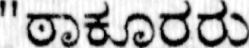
“ಠಾಕೂರರು
